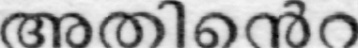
അതിന്റെ
